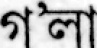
গ'লা
